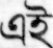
এই
